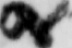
જ
